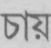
চায়
